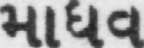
માધવ
